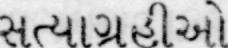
સત્યાગ્રહીઓ
